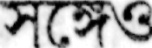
সঙ্গেও
